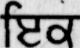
ਇਕ
